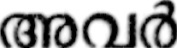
അവര്‍
